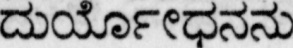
ದುರ್ಯೋಧನನು
